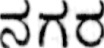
ನಗರ
